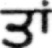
ਤਾਂ
